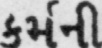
કર્મની
